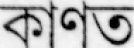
কাণত
